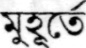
মুহূর্তে
